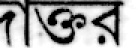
দাক্তর
